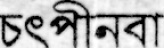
চৎপীনবা
